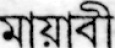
মায়াবী
